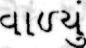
વાળ્યું
